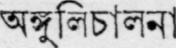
অঙ্গুলিচালনা
